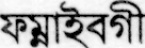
ফম্নাইবগী
